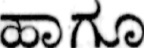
ಹಾಗೂ
